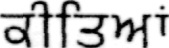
ਕੀਤਿਆਂ
